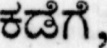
ಕಡೆಗೆ,
